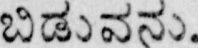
ಬಿಡುವನು.
